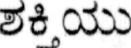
ಶಕ್ತಿಯು
